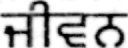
ਜੀਵਨ
